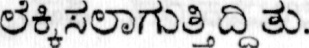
ಲೆಕ್ಕಿಸಲಾಗುತ್ತಿದ್ದಿತು.
